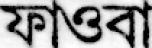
ফাওবা
